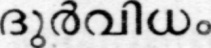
ദുര്‍വിധം
